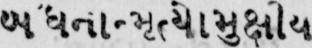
બંધનાન્મૃત્યોમુક્ષીય
